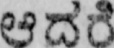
ಆದರೆ
